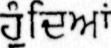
ਹੁੰਦਿਆਂ
